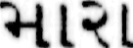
મારા
